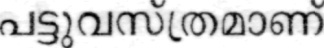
പട്ടുവസ്ത്രമാണ്
